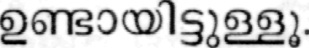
ഉണ്ടായിട്ടുള്ളൂ.
